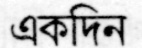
একদিন
